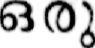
ഒരു
